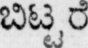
ಬಿಟ್ಟರೆ
